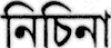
নিচিনা
